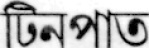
টিনপাত
